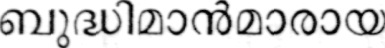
ബുദ്ധിമാന്‍മാരായ
